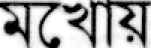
মখোয়
